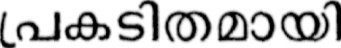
പ്രകടിതമായി
